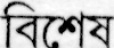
বিশেষ
